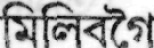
মিলিবগৈ
